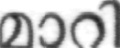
മാറി
